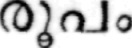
രൂപം
